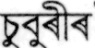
চুবুৰীৰ
